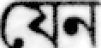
যেন
